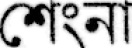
শেংনা
